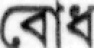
বোধ
